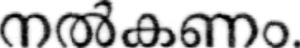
നല്‍കണം.
